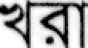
খরা
